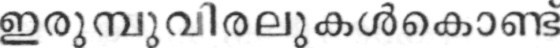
ഇരുമ്പുവിരലുകള്‍കൊണ്ട്
